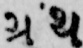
ગ્રંથ
